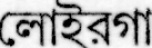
লোইরগা
